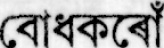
বোধকৰোঁ
